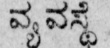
ವ್ಯವಸ್ಥೆ
